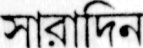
সারাদিন
